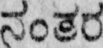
ನಂತರ
